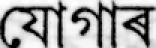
যোগাৰ
